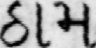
ઠામ
